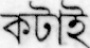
কটাই
